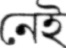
নেই
